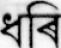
ধৰি
